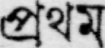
প্রথম
